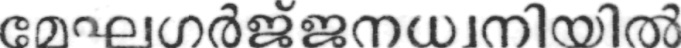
മേഘഗര്‍ജ്ജനധ്വനിയില്‍
